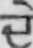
ਦੇ
